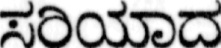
ಸರಿಯಾದ
